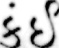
કંઈ
